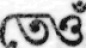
তেওঁ
